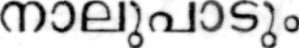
നാലുപാടും
